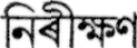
নিৰীক্ষণ
